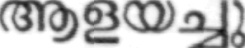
ആളയച്ചു
